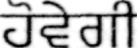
ਹੋਵੇਗੀ
